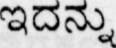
ಇದನ್ನು
